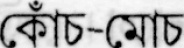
কোঁচ-মোচ
